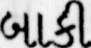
બાકી
